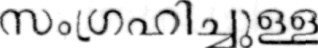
സംഗ്രഹിച്ചുള്ള
